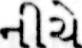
નીચે
